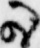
જે
